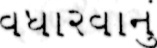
વધારવાનું
